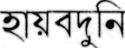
হায়বদুনি
